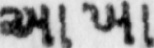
આખા
